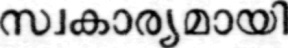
സ്വകാര്യമായി
